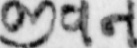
જીવન
